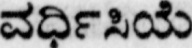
ವರ್ಧಿಸಿಯೆ
